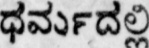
ಧರ್ಮದಲ್ಲಿ
